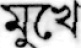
মুখে
